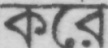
করে
